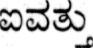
ಐವತ್ತು
